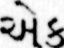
એક
